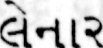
લેનાર
